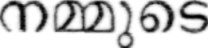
നമ്മുടെ
